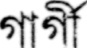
গার্গী
